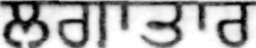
ਲਗਾਤਾਰ
